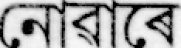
নোৱাৰে
